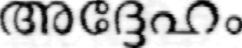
അദ്ദേഹം
